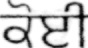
ਕੋਈ
